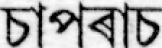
চাপৰাচ
